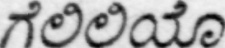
ಗೆಲಿಲಿಯೊ
